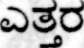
ಎತ್ತರ
